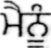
ਮੈਨੂੰ
